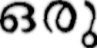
ഒരു
